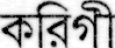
করিগী
